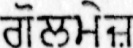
ਗੋਲਮੇਜ਼
